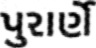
પુરાર્ણે
